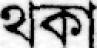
থকা
